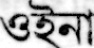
ওইনা
